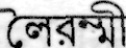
লৈরম্মী
